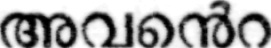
അവന്റെ
